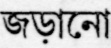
জড়ানো
